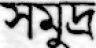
সমুদ্র
